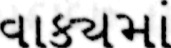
વાક્યમાં
